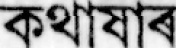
কথাষাৰ
